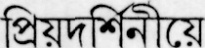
প্রিয়দৰ্শিনীয়ে
